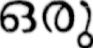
ഒരു
